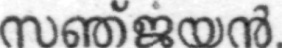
സഞ്ജയന്‍.
